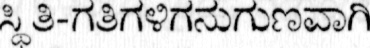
ಸ್ಥಿತಿ-ಗತಿಗಳಿಗನುಗುಣವಾಗಿ
